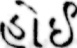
હોઈ
